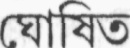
ঘোষিত
